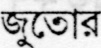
জুতোর
